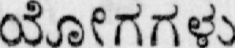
ಯೋಗಗಳು
